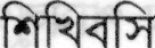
শিখিবসি
